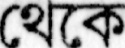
থেকে
